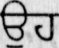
ਉਹ
